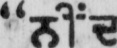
''ਨੀਂਦ
